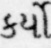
કર્યો
